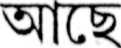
আছে
